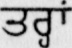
ਤਰ੍ਹਾਂ
